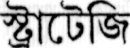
স্ট্রাটেজি
